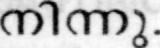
നിന്നു.
